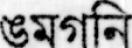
ঙমগনি
